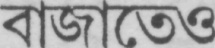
বাজাতেও
